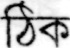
ঠিক
